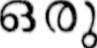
ഒരു
